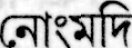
নোংমদি
